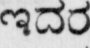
ಇದರ
